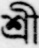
শ্রী
